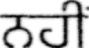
ਨਹੀਂ
